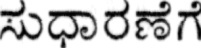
ಸುಧಾರಣೆಗೆ
